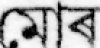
মোৰ
